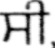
ਸੀ,
